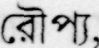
রৌপ্য,
